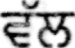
ਵੱਲ
